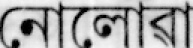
নোলোৱা
